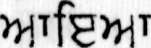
ਆਇਆ
